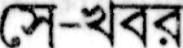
সে-খবর
